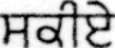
ਸਕੀਏ
